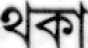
থকা
